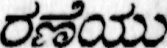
ರಣೆಯು
